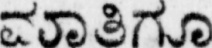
ಮಾತಿಗೂ
